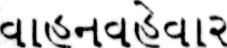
વાહનવહેવાર
